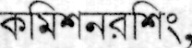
কমিশনরশিং,
